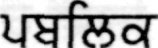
ਪਬਲਿਕ
